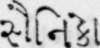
સૈનિકો
